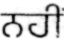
ਨਹੀਂ
